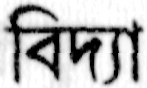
বিদ্যা
